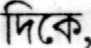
দিকে,
